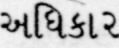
અધિકાર
